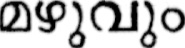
മഴുവും
